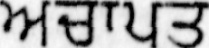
ਅਚਾਪਤ
